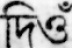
দিওঁ
